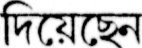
দিয়েছেন
